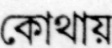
কোথায়
